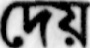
দেয়
